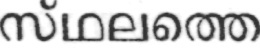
സ്ഥലത്തെ
